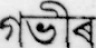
গভীৰ
